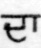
ਦਾ
